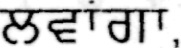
ਲਵਾਂਗਾ,
